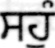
ਸਹੁੰ
